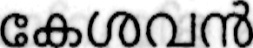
കേശവന്‍
